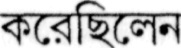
করেছিলেন
